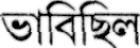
ভাবিছিল
